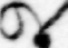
જ
